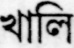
খালি
